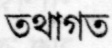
তথাগত
